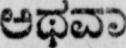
ಅಥವಾ
